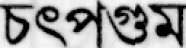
চৎপগুম
